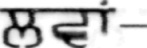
ਲਵਾਂ-
